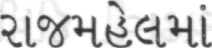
રાજમહેલમાં
